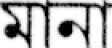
মানা
